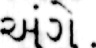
અંગે.
